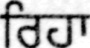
ਰਿਹਾ
